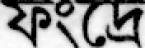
ফংদ্রে
